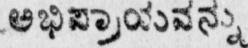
ಅಭಿಪ್ರಾಯವನ್ನು
